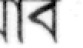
যাব
